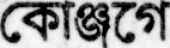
কোঞ্জগে
